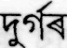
দুর্গৰ
